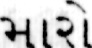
મારો
